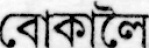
বোকালৈ
